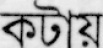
কটায়
